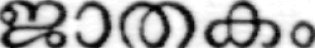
ജാതകം
